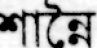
শান্নৈ
